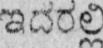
ಇದರಲ್ಲಿ
